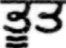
ਭੂਤ
